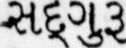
સદગુરૂ
